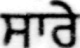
ਸਾਰੇ
